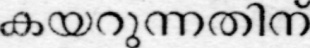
കയറുന്നതിന്
